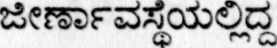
ಜೀರ್ಣಾವಸ್ಥೆಯಲ್ಲಿದ್ದ
